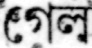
গেল
